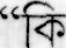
"কি
